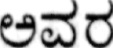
ಅವರ
